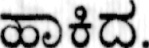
ಹಾಕಿದ.
